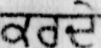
ਕਰਦੇ
